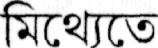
মিথ্যেতে
